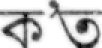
ক'ত
